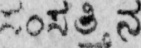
ಸಂಸತ್ತಿನ
